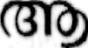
ആ
